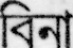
বিনা
